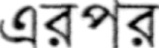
এরপর
